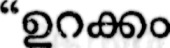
“ഉറക്കം
